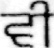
ਵੀ
